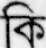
কি
